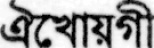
ঐখোয়গী
